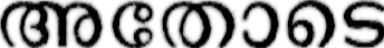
അതോടെ
